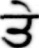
ਤੇ
